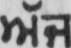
ਅੱਜ
